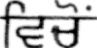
ਵਿਚੋਂ
